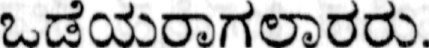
ಒಡೆಯರಾಗಲಾರರು.
